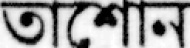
তাশোন
